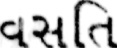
વસતિ
